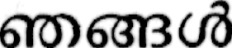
ഞങ്ങള്‍
